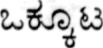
ಒಕ್ಕೂಟ
